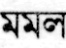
মমল
